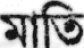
মাতি
